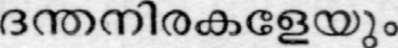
ദന്തനിരകളേയും
